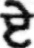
ਏ
